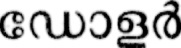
ഡോളര്‍
